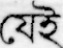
যেই
